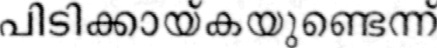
പിടിക്കായ്കയുണ്ടെന്ന്
